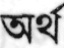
অর্থ
